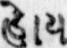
હોય
